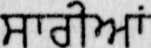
ਸਾਰੀਆਂ
